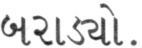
બરાડ્યો.
